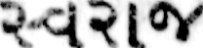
સ્વરાજ
